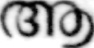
ആ
